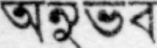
অনুভব
